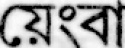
য়েংবা
